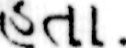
હતા.
